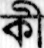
কী
